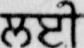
ਲਈ
